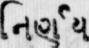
નિર્ણય
